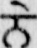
ਨੇ
